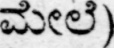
ಮೇಲೆ)
